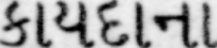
કાયદાના
